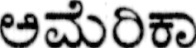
ಅಮೆರಿಕಾ
